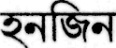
হনজিন
